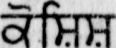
ਕੋਸ਼ਿਸ਼
